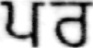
ਪਰ
